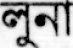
লুনা
